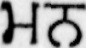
ਮਨ
